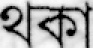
থকা
